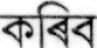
কৰিব
